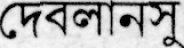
দেবলানসু
